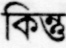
কিন্তু
